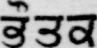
ਭੌਤਕ
